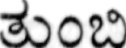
ತುಂಬಿ
